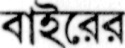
বাইরের
